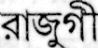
রাজুগী
